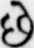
છે
